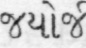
જ્યોર્જ
